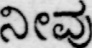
ನೀವು
